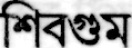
শিবগুম
